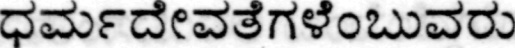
ಧರ್ಮದೇವತೆಗಳೆಂಬುವರು
